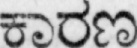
ಕಾರಣ
